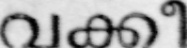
വക്കീ
